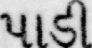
પાડી
